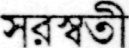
সরস্বতী
